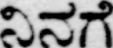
ನಿನಗೆ
